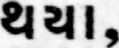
થયા,
